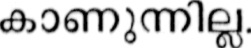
കാണുന്നില്ല.
